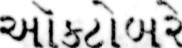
ઑક્ટોબરે
